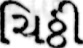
ચિઠ્ઠી
